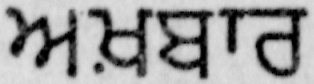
ਅਖ਼ਬਾਰ
